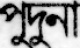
পুদুনা
